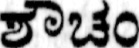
ಶೌಚಂ
